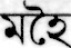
মহৈ
